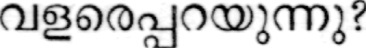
വളരെപ്പറയുന്നു?
